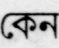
কেন
